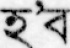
হ'ব
